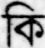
কি
